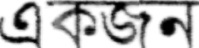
একজন
